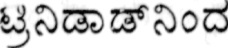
ಟ್ರಿನಿಡಾಡ್ ನಿಂದದ
